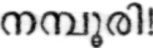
നമ്പൂരി!
